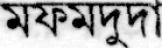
মফমদুদা
